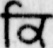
ਕਿ
